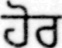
ਹੋਰ
